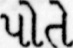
પોતે
